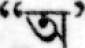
"অ'
